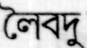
লৈবদু
